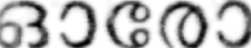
ഓരോ
